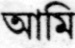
আমি
